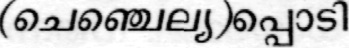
(ചെഞ്ചെല്യ)പ്പൊടി
